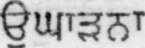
ਉਘਾੜਨਾ
